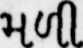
મળી
